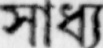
সাধ্য
